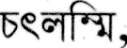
চৎলম্মি,
